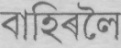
বাহিৰলৈ
